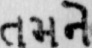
તમને
